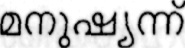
മനുഷ്യന്ന്
